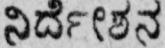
ನಿರ್ದೇಶನ
